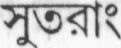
সুতরাং
